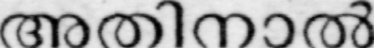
അതിനാല്‍
